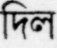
দিল
